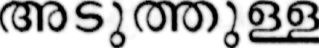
അടുത്തുള്ള
